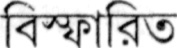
বিস্ফারিত
